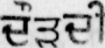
ਦੌੜਦੀ
